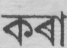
কৰা
